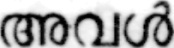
അവള്‍
